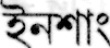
ইনশাং
